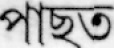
পাছত
